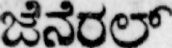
ಜೆನೆರಲ್
